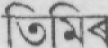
তিমিৰ
